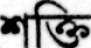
শক্তি
